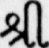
શ્રી
